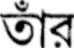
তাঁর
